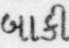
બાકી
